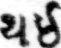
થઈ
